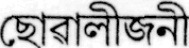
ছোৱালীজনী
